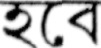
হবে
